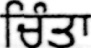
ਚਿੰਤਾ
